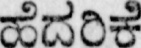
ಹೆದರಿಕೆ
